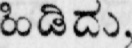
ಹಿಡಿದು,
